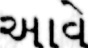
આવે
